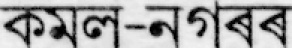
কমল-নগৰৰ
